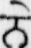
ਨੇ
